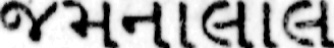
જમનાલાલ
